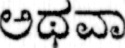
ಅಥವಾ
